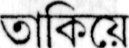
তাকিয়ে
